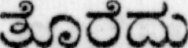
ತೊರೆದು
